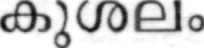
കുശലം
